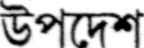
উপদেশ
